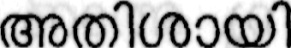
അതിശായി
